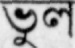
ভুল
